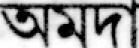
অমদা
